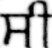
ਸੀ
